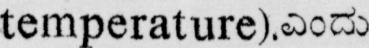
temperature)ಎಂದು
